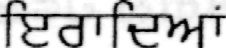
ਇਰਾਦਿਆਂ
